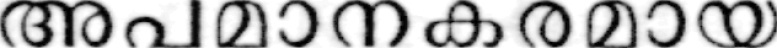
അപമാനകരമായ
